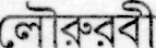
লৌররবী
